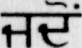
ਜਦੋਂ
